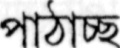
পাঠাচ্ছ
